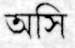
অসি
